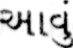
આવું
